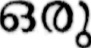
ഒരു
